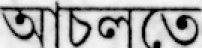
আচলতে
